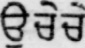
ਉਚੇਚੇ
